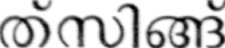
ത്സിങ്ങ്
